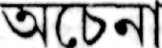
অচেনা
